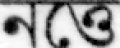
নত্তে
